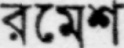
রমেশ
